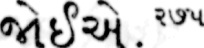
જોઈએ.૨૭૫
